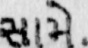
સામે.
